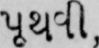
પૃથ્વી,
